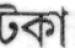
টকা
